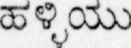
ಹಳ್ಳಿಯು
